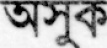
অসুক
